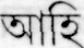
আহি
